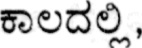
ಕಾಲದಲ್ಲಿ,
